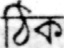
ঠিক
